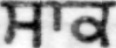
ਸਾਕ
